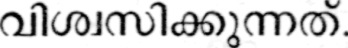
വിശ്വസിക്കുന്നത്.
